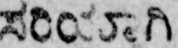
ಸರಿಯಾಗಿ
